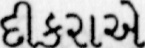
દીકરાએ
